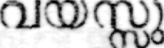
വയസ്സു
